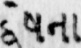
દ્વેષના
